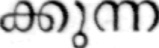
ക്കുന്ന
